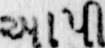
આપી
